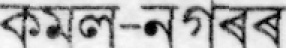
কমল-নগৰৰ
